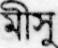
মীসু
